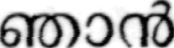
ഞാന്‍
